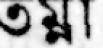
তম্না
